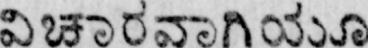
ವಿಚಾರವಾಗಿಯೂ
